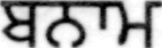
ਬਨਾਮ
